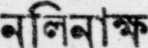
নলিনাক্ষ
